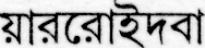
য়াররোইদবা
